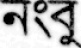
নংবু
